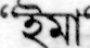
“ইমা‘
